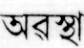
অৱস্থা
